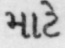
માટે
